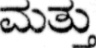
ಮತ್ತು
